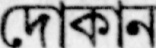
দোকান
